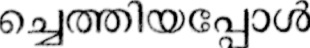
ച്ചെത്തിയപ്പോള്‍
